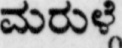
ಮರುಳ್ಗೆ
